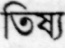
তিষ্য
